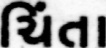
ચિંતા
